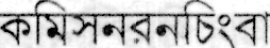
কমিসনরনচিংবা
